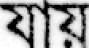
যায়
